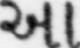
આ
